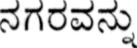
ನಗರವನ್ನು
